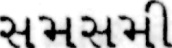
સમસમી
